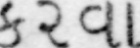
કરવા
